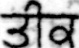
ਤੀਕ
